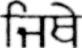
ਜਿਥੇ
